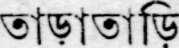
তাড়াতাড়ি
